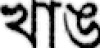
খাঙ
